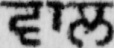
ਵਾਲ
